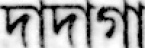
দাদাগা
